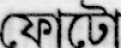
ফোটো
